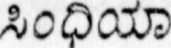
ಸಿಂಧಿಯಾ
